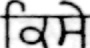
ਕਿਸੇ
